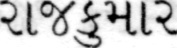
રાજકુમાર
